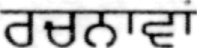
ਰਚਨਾਵਾਂ
